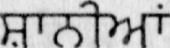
ਸ਼ਾਨੀਆਂ
